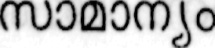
സാമാന്യം
